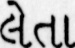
લેતા
